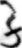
કે
